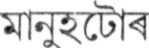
মানুহটোৰ
